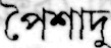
পৈশাদু
